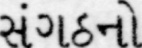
સંગઠનો
